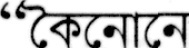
“কৈনোনে
